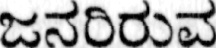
ಜನರಿರುವ
